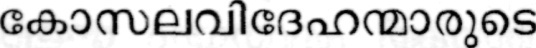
കോസലവിദേഹന്മാരുടെ
